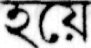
হয়ে
